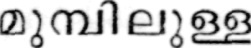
മുമ്പിലുള്ള
